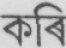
কৰি
